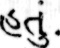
હતું.
